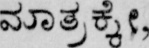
ಮಾತ್ರಕ್ಕೇ,
